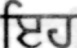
ਇਹ
